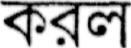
করল
